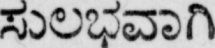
ಸುಲಭವಾಗಿ
